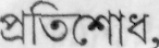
প্রতিশোধ,
